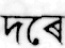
দৰে
